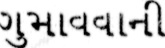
ગુમાવવાની
